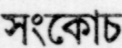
সংকোচ
